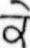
ਕੇ
